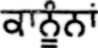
ਕਾਨੂੰਨਾਂ
